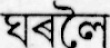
ঘৰলৈ
